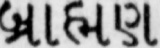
બ્રાહ્મણ
